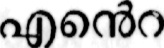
എന്റെ
